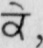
ਕੇ,
